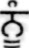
ਨੂੰ
